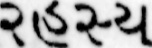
રહસ્ય
